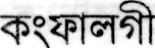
কংফালগী
